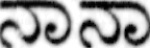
ನಾನಾ
